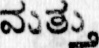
ಮತ್ತು
